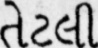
તેટલી
